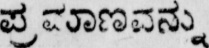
ಪ್ರಮಾಣವನ್ನು
